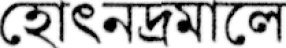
হোৎনদ্রমালে
